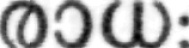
രാധ:
